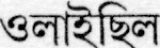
ওলাইছিল
